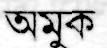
অমুক
